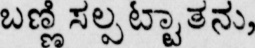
ಬಣ್ಣಿಸಲ್ಪಟ್ಟಾತನು,
